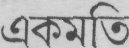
একমতি
